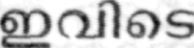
ഇവിടെ
